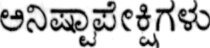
ಅನಿಷ್ಟಾಪೇಕ್ಷಿಗಳು
